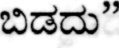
ಬಿಡದು’’
